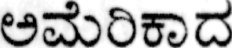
ಅಮೆರಿಕಾದ
